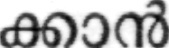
ക്കാന്‍
